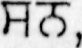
ਸਨ,
